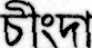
চীংদা
